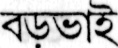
বড়ভাই
